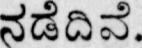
ನಡೆದಿವೆ.
